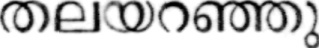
തലയറഞ്ഞു
